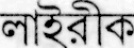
লাইরীক
